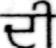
ਦੀ
